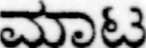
ಮಾಟ
